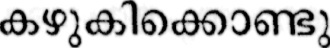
കഴുകിക്കൊണ്ടു
